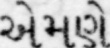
એમણે
